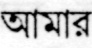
আমার
